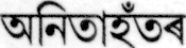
অনিতাহঁতৰ
